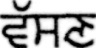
ਵੱਸਣ
